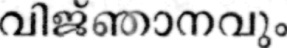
വിജ്ഞാനവും
